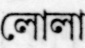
লোলা
